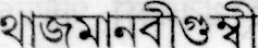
থাজমানবীগুম্বী
